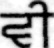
ਵੀ
